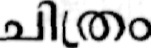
ചിത്രം
